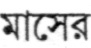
মাসের
